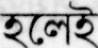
হলেই
